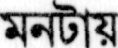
মনটায়
